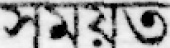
সময়ত
